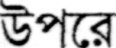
উপরে
